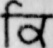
ਕਿ
